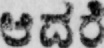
ಆದರೆ
